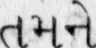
તમને
